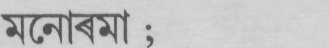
মনোৰমা;
